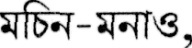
মচিন-মনাও,
